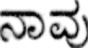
ನಾವು
